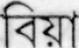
বিয়া
